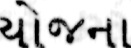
યોજના
